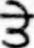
ਤੇ
